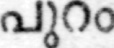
പുറം
